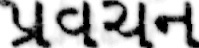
પ્રવચન
